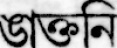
ঙক্তনি
